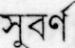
সুবর্ণ
